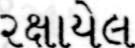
રક્ષાયેલ
